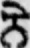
ਨੇ
